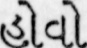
હોવા
